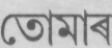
তোমাৰ
